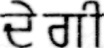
ਦੇਗੀ
